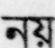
নয়
